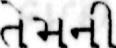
તેમની
